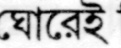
ঘোরেই
